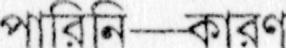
পারিনি–কারণ
